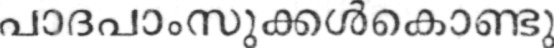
പാദപാംസുക്കള്‍കൊണ്ടു
